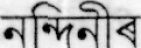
নন্দিনীৰ
